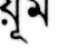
য়ূম
